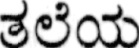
ತಲೆಯ
